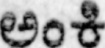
ಅಂಕಿ
